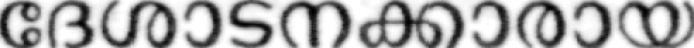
ദേശാടനക്കാരായ
